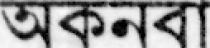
অকনবা
